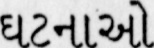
ઘટનાઓ
